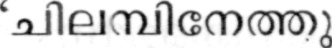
'ചിലമ്പിനേത്തു
